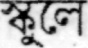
স্কুলে
